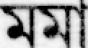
মমা
